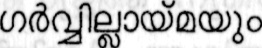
ഗര്‍വ്വില്ലായ്മയും
